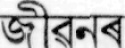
জীৱনৰ
